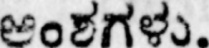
ಅಂಶಗಳು.
